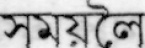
সময়লৈ
